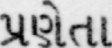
પ્રણેતા
